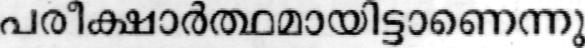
പരീക്ഷാര്‍ത്ഥമായിട്ടാണെന്നു
